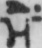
ਮੈਂ
